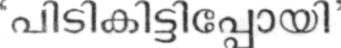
‘പിടികിട്ടിപ്പോയി'
